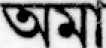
অমা
